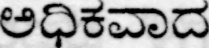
ಅಧಿಕವಾದ
